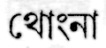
থোংনা
